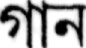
গান
